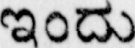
ಇಂದು
